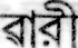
ৱারী
